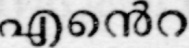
എന്റെ
